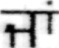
ਜਾਂ
